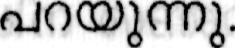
പറയുന്നു.
